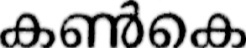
കണ്‍കെ
